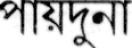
পায়দুনা
